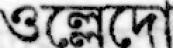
ওল্লেদো
